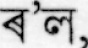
ৰ'ল,
